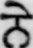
ਨੇ
